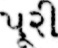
પૂરી
